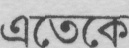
এতেকে
